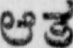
ಆತ
